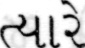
ત્યારે
